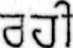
ਰਹੀ
